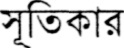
সূতিকার
